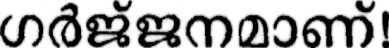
ഗര്‍ജ്ജനമാണ്!
